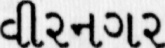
વીરનગર
